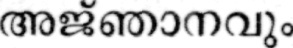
അജ്ഞാനവും
